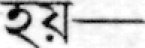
হয়-
